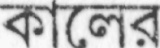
কালের
